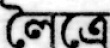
লৈত্রে
